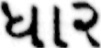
ધાર
